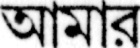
আমার
